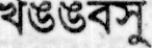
খঙঙবসু
